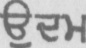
ਉਦਮ
